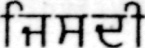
ਜਿਸਦੀ
